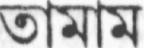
তামাম
